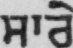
ਸਾਰੇ
